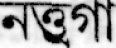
নত্ত্রগা
